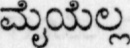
ಮೈಯೆಲ್ಲ
